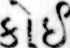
કોઈ
